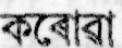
কৰোৱা
